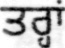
ਤਰ੍ਹਾਂ
